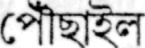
পৌঁছাইল
